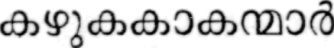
കഴുകകാകന്മാര്‍
